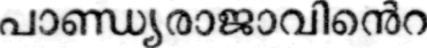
പാണ്ഡ്യരാജാവിന്റെ
